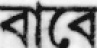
বাবে
